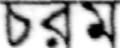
চরম
